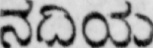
ನದಿಯ
